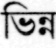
ভিন্ন
